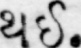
થઈ.
